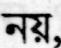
নয়,
